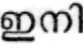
ഇനി
